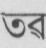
তৱ
